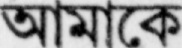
আমাকে
